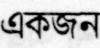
একজন
